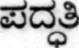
ಪದ್ಧತಿ
